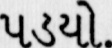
પડયો.
